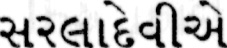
સરલાદેવીએ
